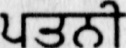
ਪਤਨੀ
